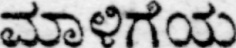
ಮಾಳಿಗೆಯ
